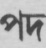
পদ
